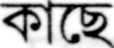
কাছে
